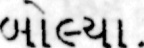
બોલ્યા.
